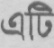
এটি
